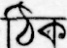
ঠিক
